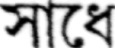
সাধে
